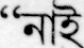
"নাই
